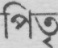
পিতৃ
